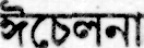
ঈচেলনা
